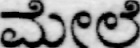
ಮೇಲೆ
